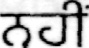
ਨਹੀਂ
